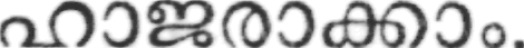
ഹാജരാക്കാം.
